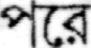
পরে
